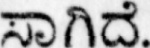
ಸಾಗಿದೆ.
